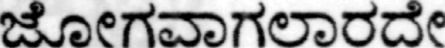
ಜೋಗವಾಗಲಾರದೇ
